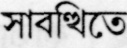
সাবত্থিতে
